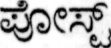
ಪೋಸ್ಟ್
